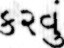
કરવું
